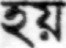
হয়
